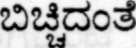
ಬಿಚ್ಚಿದಂತೆ
